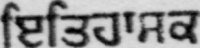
ਇਤਿਹਾਸਕ
